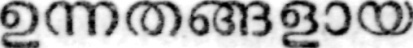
ഉന്നതങ്ങളായ
